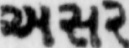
અસર
